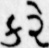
કરે
